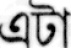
এটা
